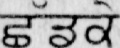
ਛੱਡਕੇ
